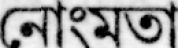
নোংমতা
